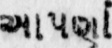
આપણાં
